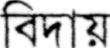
বিদায়
